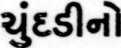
ચુંદડીનો
